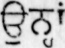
ਉਨ੍ਹਾਂ
